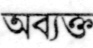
অব্যক্ত
